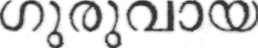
ഗുരുവായ
